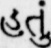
હતું
